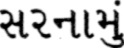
સરનામું
